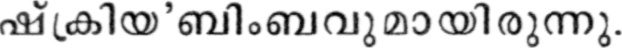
ഷ്ക്രിയ'ബിംബവുമായിരുന്നു.
